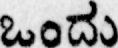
ಒಂದು
